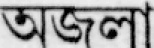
অজলা
